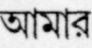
আমার
